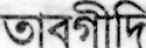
তাবগীদি
